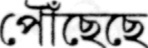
পৌঁছেছে
